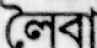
লৈবা
